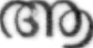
ആ
